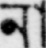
না
